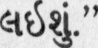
લઈશું."
